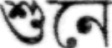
শুনে
